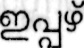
ഇപ്പഴ്
